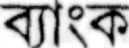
ব্যাংক
